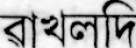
ৱাখলদি
